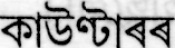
কাউণ্টাৰৰ
